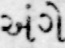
અંગે
